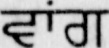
ਵਾਂਗ
